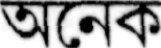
অনেক
